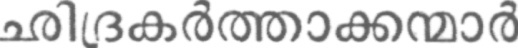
ഛിദ്രകര്‍ത്താക്കന്മാര്‍
